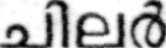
ചിലര്‍
